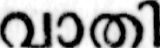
വാതി
